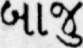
બાજુ
